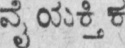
ವೈಯಕ್ತಿಕ
